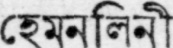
হেমনলিনী
